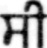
ਸੀ
